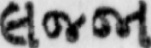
લજ્જા
